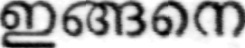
ഇങ്ങനെ
